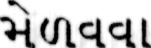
મેળવવા
